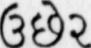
ઉછેર
